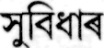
সুবিধাৰ
